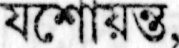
যশোয়ন্ত,
